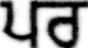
ਪਰ
